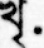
খৃ.
